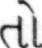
તો
